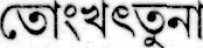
তোংখৎতুনা
